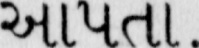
આપતા.
